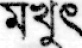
মখুৎ
